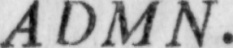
ADMN.
